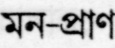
মন-প্রাণ
